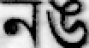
নঙ
